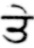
ਤੇ
